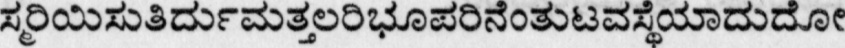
ಸ್ಮರಿಯಿಸುತಿರ್ದುಮತ್ತಲರಿಭೂಪರಿನೆಂತುಟವಸ್ಥೆಯಾದುದೋ
